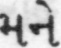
મને
